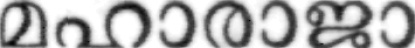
മഹാരാജാ
